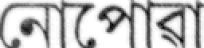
নোপোৱা
